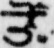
ਤੋਂ
